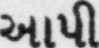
આપી
